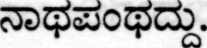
ನಾಥಪಂಥದ್ದು.
